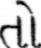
તો
